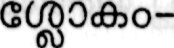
ശ്ലോകം-
